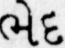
ભેદ
